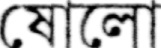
ষোলো
